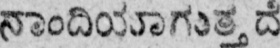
ನಾಂದಿಯಾಗುತ್ತದೆ
